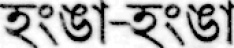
হংঙা-হংঙা
